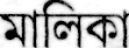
মালিকা
